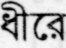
ধীরে
